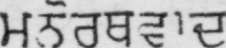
ਮਨੋਰਥਵਾਦ
